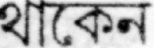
থাকেন
